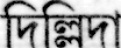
দিল্লিদা
